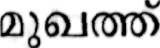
മുഖത്ത്
